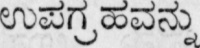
ಉಪಗ್ರಹವನ್ನು
